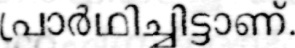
പ്രാര്‍ഥിച്ചിട്ടാണ്.
